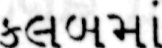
ક્લબમાં
